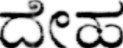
ದೇಹ
